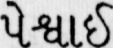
પેશ્વાઈ
